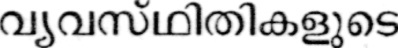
വ്യവസ്ഥിതികളുടെ
